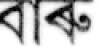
বাৰু
